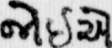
જોઈએ
